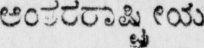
ಅಂತರರಾಷ್ಟ್ರೀಯ
